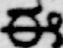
ಈ
